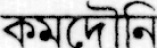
কমদৌনি
